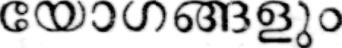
യോഗങ്ങളും
